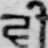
ਵੀ
